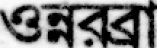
ওন্নরব্রা
